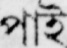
পাই
